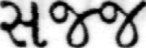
સજ્જ
